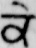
ਕੇ
